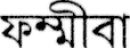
ফম্মীবা
